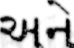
અને
